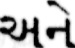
અને
